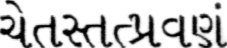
ચેતસ્તત્પ્રવણં
